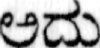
ಅದು
